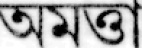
অমত্তা
